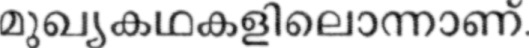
മുഖ്യകഥകളിലൊന്നാണ്.
